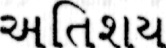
અતિશય
